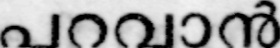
പറവാന്‍
